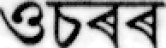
ওচৰৰ
